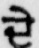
ਦੇ
